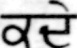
ਕਦੇ
